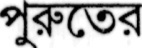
পুরুতের
